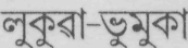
লুকুৱা-ভুমুকা
